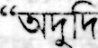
“অদুদি
